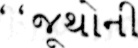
"જૂથોની
